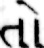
તો
